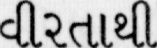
વીરતાથી
